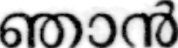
ഞാന്‍
